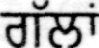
ਗੱਲਾਂ
